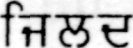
ਜਿਲਦ
